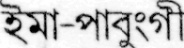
ইমা-পাবুংগী
